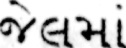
જેલમાં
